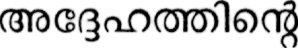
അദ്ദേഹത്തിന്റെ
